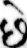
છે
